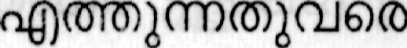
എത്തുന്നതുവരെ
